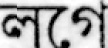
লগে
